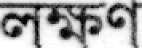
লক্ষণ
